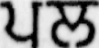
ਪਲ
